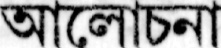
আলোচনা
